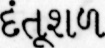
દંતશૂળ
